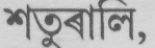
শতুৰালি,
